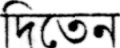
দিতেন
